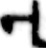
ન
